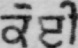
ਕੋਈ
